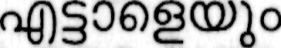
എട്ടാളെയും
